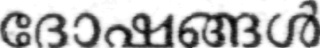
ദോഷങ്ങള്‍
